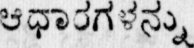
ಆಧಾರಗಳನ್ನು
